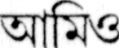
আমিও
